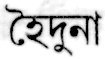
হৈদুনা
